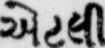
એટલી
